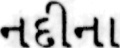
નદીના
